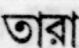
তারা
